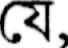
যে,
